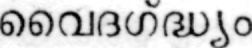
വൈദഗ്ദ്ധ്യം
